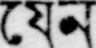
যেন
